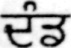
ਦੰਡ
